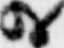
જ
